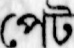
পেট
